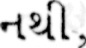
નથી,
